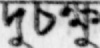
দুচক্ষু
